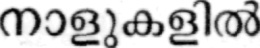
നാളുകളില്‍
